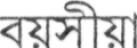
বয়সীয়া
